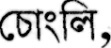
চোংলি,
